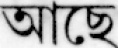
আছে
